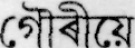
গৌৰীয়ে
